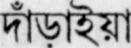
দাঁড়াইয়া
